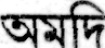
অমদি
